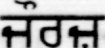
ਜੌਰਜ਼
